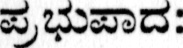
ಪ್ರಭುಪಾದ:
